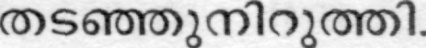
തടഞ്ഞുനിറുത്തി.
